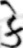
કે
